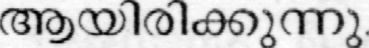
ആയിരിക്കുന്നു.
